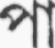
পা
